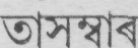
তাসম্বাৰ
